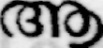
ആ
